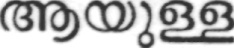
ആയുള്ള
